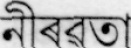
নীৰৱতা
